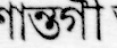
শান্তগী
